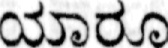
ಯಾರೂ
